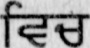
ਵਿਚ
